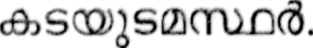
കടയുടമസ്ഥര്‍.
